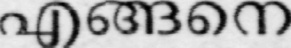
എങ്ങനെ
